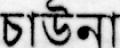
চাউনা
